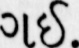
ગઈ.
